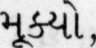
મૂક્યો,
